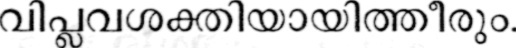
വിപ്ലവശക്തിയായിത്തീരും.
